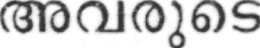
അവരുടെ
